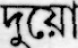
দুয়ো
